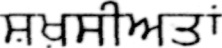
ਸ਼ਖ਼ਸ਼ੀਅਤਾਂ
